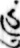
હું
